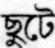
ছুটে
